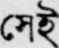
সেই
